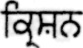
ਕ੍ਰਿਸ਼ਨ
